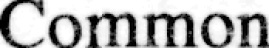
Common
